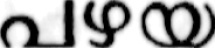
പഴയ
